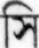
সি
